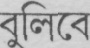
বুলিবে
